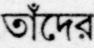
তাঁদের
